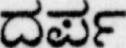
ದರ್ಪ
